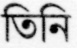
তিনি
